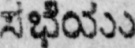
ಸಭೆಯು
